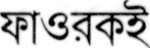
ফাওরকি
